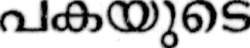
പകയുടെ
